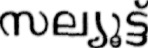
സല്യൂട്ട്
